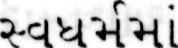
સ્વધર્મમાં
